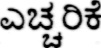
ಎಚ್ಚರಿಕೆ
